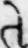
તે
